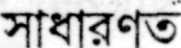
সাধারণত
